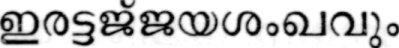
ഇരട്ടജ്ജയശംഖവും
